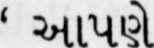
'આપણે
